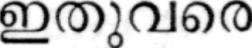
ഇതുവരെ
